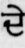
ਦੇ
